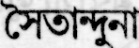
সৈতান্দুনা
